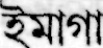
ইমাগা
